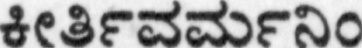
ಕೀರ್ತಿವರ್ಮನಿಂ
